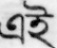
এই
